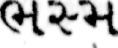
ભસ્મ
